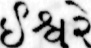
ઈશ્વરે
